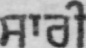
ਸਾਰੀ
